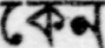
কেন
